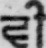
ਵੀ
